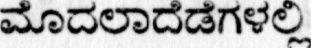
ಮೊದಲಾದೆಡೆಗಳಲ್ಲಿ
